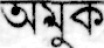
অমুক
